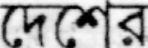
দেশের
